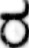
ರ
